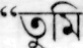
"তুমি
